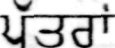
ਪੱਤਰਾਂ
